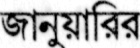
জানুয়ারির
